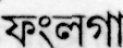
ফংলগা
